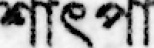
শাৎপা
